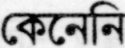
কেনেনি
